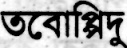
তবোপ্পিদু
